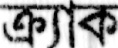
ক্র্যাক
